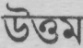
উত্তম
